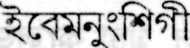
ইবেমনুংশিগী
